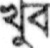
খুব
